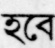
হবে
